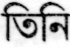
তিনি
